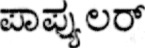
ಪಾಪ್ಯುಲರ್
